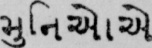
મુનિઓએ
